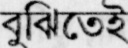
বুঝিতেই
